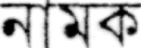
নামক
